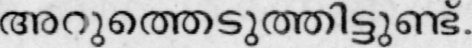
അറുത്തെടുത്തിട്ടുണ്ട്.
